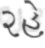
રહે
